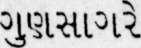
ગુણસાગરે
